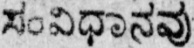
ಸಂವಿಧಾನವು
